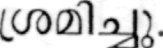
ശ്രമിച്ചു.
